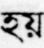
হয়
